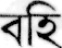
বহি
